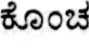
ಕೊಂಚ
